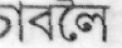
চাবলৈ
